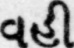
વહી
